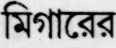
মিগারের
